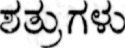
ಶತ್ರುಗಳು
